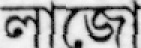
লাজো
